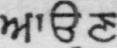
ਆਉਣ
